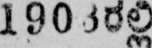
1903ರಲ್ಲಿ
